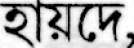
হায়দে,
